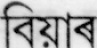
বিয়াৰ
